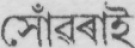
সোঁৱৰাই
